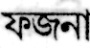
ফজনা
